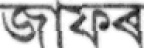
জাফৰ
